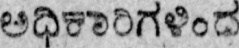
ಅಧಿಕಾರಿಗಳಿಂದ
